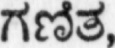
ಗಣಿತ,
